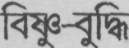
বিষ্ণু-বুদ্ধি
